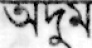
অদুম
